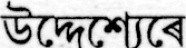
উদ্দেশ্যেৰে
